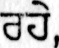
ਰਹੇ,
